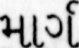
માર્ગ
